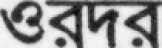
ওরদর
